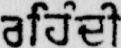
ਰਹਿੰਦੀ
